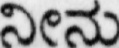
ನೀನು
